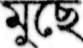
মুছে
